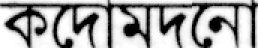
কদোমদনো
